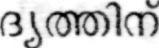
ദ്യത്തിന്
